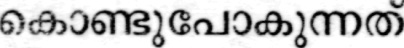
കൊണ്ടുപോകുന്നത്
